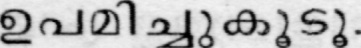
ഉപമിച്ചുകൂടൂ.
